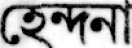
হেন্দনা
